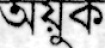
অয়ুক
